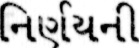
નિર્ણયની
